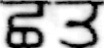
ਛਤ
